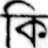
কি
